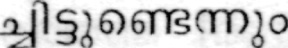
ച്ചിട്ടുണ്ടെന്നും
